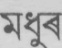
মধুৰ
